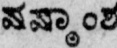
ಷಷ್ಠಾಂಶ
